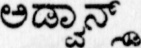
ಅಡ್ವಾನ್ಸ್ಡ್
